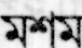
মশম
